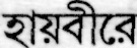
হায়বীরে
